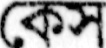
কেস
